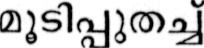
മൂടിപ്പുതച്ച്
